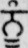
ਨੂੰ
